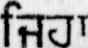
ਜਿਹਾ
